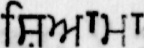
ਸ਼ਿਆਮਾ
